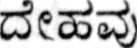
ದೇಹವು
